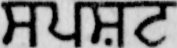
ਸਪਸ਼ਟ
